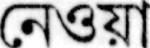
নেওয়া
